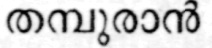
തമ്പുരാന്‍
